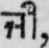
ਜੀ,
